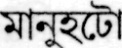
মানুহটো
